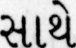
સાથે
